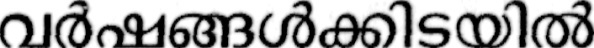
വര്‍ഷങ്ങള്‍ക്കിടയില്‍
